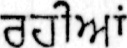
ਰਹੀਆਂ
